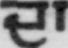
ਦਾ
